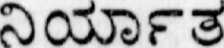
ನಿರ್ಯಾತ
